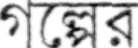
গল্পের
